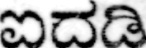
ಐದಡಿ
